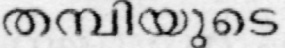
തമ്പിയുടെ
